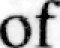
of
